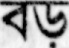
বড়
